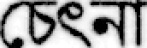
চেৎনা
